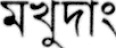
মখুদাং
